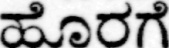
ಹೊರಗೆ
